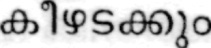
കീഴടക്കും
